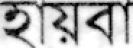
হায়বা
